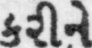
કરીને
